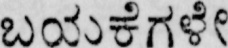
ಬಯಕೆಗಳೇ
